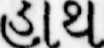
હાથ
